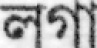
লগা
